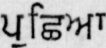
ਪੁਛਿਆ
